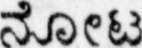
ನೋಟ
